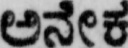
ಅನೇಕ
